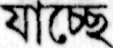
যাচ্ছে
